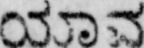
ಯಾವ
